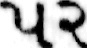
પર
